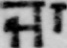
ਜਾ
